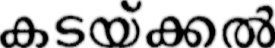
കടയ്ക്കല്‍
